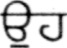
ਉਹ
